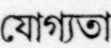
যোগ্যতা
